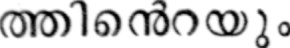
ത്തിന്റെയും
